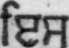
ਇਸ
